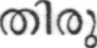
തിരു
